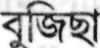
বুজিছা
